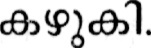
കഴുകി.
